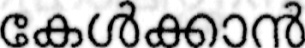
കേള്‍ക്കാന്‍
